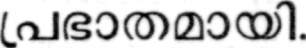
പ്രഭാതമായി.
